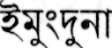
ইমুংদুনা
